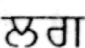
ਲਗ
